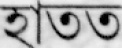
হাতত
